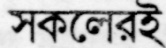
সকলেরই
